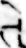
તે
